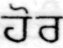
ਹੋਰ
